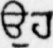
ਉਹ
